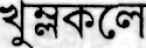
খুম্লকলে
